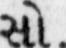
સો.
